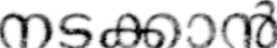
നടക്കാന്‍
